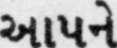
આપને
